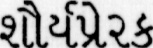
શૌર્યપ્રેરક
